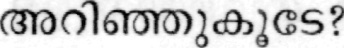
അറിഞ്ഞുകൂടേ?
